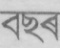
বছৰ
